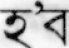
হ'ব
